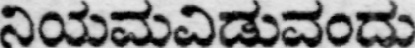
ನಿಯಮವಿಡುವಂದು
